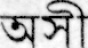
অসী
